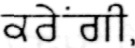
ਕਰੇਂਗੀ,
